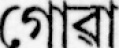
গোৱা
